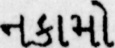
નકામો
